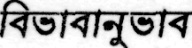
বিভাবানুভাব
